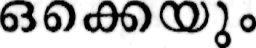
ഒക്കെയും
